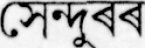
সেন্দুৰৰ
